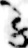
કે
